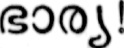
ഭാര്യ!
